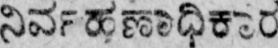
ನಿರ್ವಹಣಾಧಿಕಾರ
